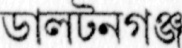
ডালটনগঞ্জ
